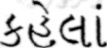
કહેલાં
